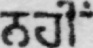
ਨਹੀਂ
